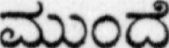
ಮುಂದೆ
